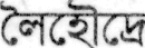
লৈহৌদ্রে
